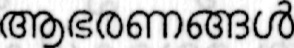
ആഭരണങ്ങള്‍
